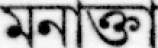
মনাক্তা
